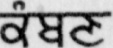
ਕੰਬਣ
